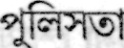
পুলিসতা
